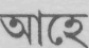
আহে
